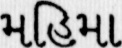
મહિમા
